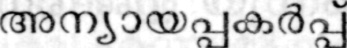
അന്യായപ്പകര്‍പ്പ്
